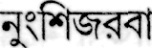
নুংশিজরবা
